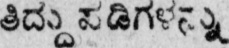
ತಿದ್ದುಪಡಿಗಳನ್ನು
